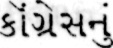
કૉંગ્રેસનું
